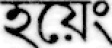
হয়েং
